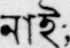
নাই,
